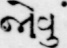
જોવું
